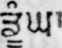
ਡੂੰਘਾ
